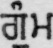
ਗੁੰਮ
